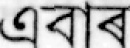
এবাৰ
